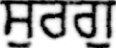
ਸੁਰਗੁ
